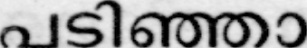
പടിഞ്ഞാ
